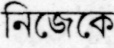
নিজেকে
